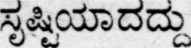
ಸೃಷ್ಟಿಯಾದದ್ದು
